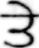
ਤੇ
